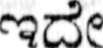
ಇದೇ
